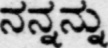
ನನ್ನನ್ನು
